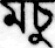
মচু
